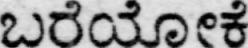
ಬರೆಯೋಕೆ
